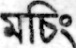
মচিং
